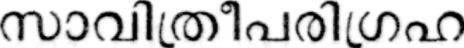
സാവിത്രീപരിഗ്രഹ
